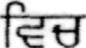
ਵਿਚ
